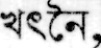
খৎনৈ,
